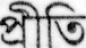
প্রীতি
